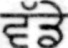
ਵੱਡੇ
